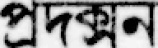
প্রদক্সন
